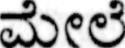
ಮೇಲೆ
